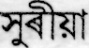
সুৰীয়া
